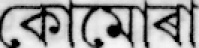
কোমোৰা
